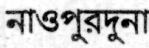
নাওপুরদুনা
